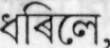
ধৰিলে,
